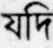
যদি
